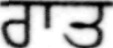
ਰਾਤ
